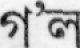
গ'ল
